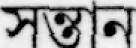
সন্তান
